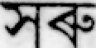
সৰু
